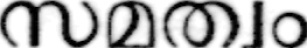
സമത്വം
